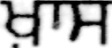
ਖ਼ਾਸ
